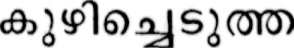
കുഴിച്ചെടുത്ത
